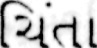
ચિંતા
